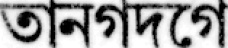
তানগদগে
